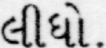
લીધો.
